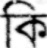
কি
